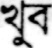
খুব
